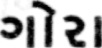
ગોરા
